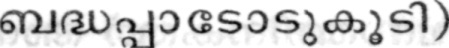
ബദ്ധപ്പാടോടുകൂടി)
